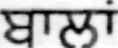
ਬਾਲਾਂ
